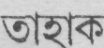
তাহাক
